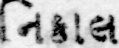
નિકાલ
